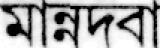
মান্নদবা
